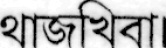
থাজখিবা।
